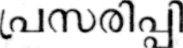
പ്രസരിപ്പി
